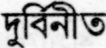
দুর্বিনীত
